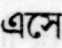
এসে
